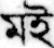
মই
